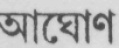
আঘোণ
